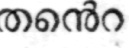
തന്റെ
